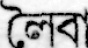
লৈবা
